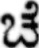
ಚೆ
